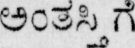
ಅಂತಸ್ತಿಗೆ
